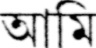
আমি
